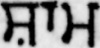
ਸ਼ਾਮ
